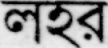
লহর
